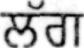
ਲੱਗ
